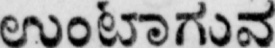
ಉಂಟಾಗುವ
